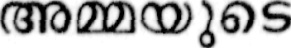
അമ്മയുടെ
